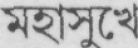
মহাসুখে
